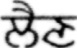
ਲੈਣ
